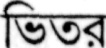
ভিতর
